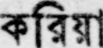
করিয়া
